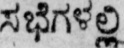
ಸಭೆಗಳಲ್ಲಿ
